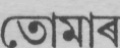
তোমাৰ
